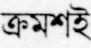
ক্রমশই
